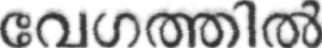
വേഗത്തില്‍
